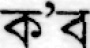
ক'ব
